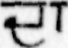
ਦਾ
